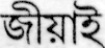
জীয়াই
